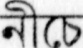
নীচে
